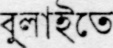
বুলাইতে
